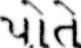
પોતે
